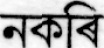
নকৰি
